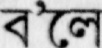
ব'লে
